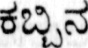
ಕಬ್ಬಿನ
